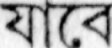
যাবে
